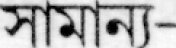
সামান্য-
